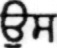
ਉਸ
